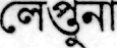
লেপ্তুনা
